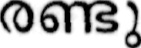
രണ്ടു
